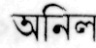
অনিল
